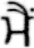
ਮੈਂ
